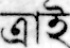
ত্রাই
